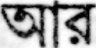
আর
